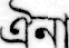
ঐনা
